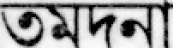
তমদনা
